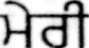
ਮੇਰੀ
